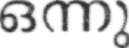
ഒന്നു
